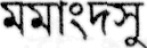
মমাংদসু
